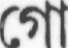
গো
